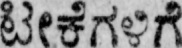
ಟೀಕೆಗಳಿಗೆ
